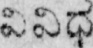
ವಿವಿಧ
